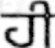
ਹੀ
